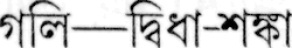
গলি-দ্বিধা-শঙ্কা
